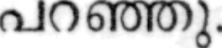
പറഞ്ഞു.
